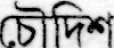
চৌদিশ
